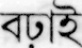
বঢ়াই
